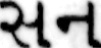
સન
